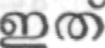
ഇത്
